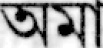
অমা
